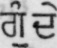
ਗੁੰਦੇ
